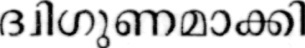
ദ്വിഗുണമാക്കി
